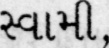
સ્વામી,
